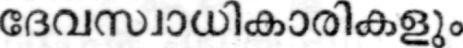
ദേവസ്വാധികാരികളും
